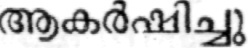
ആകര്‍ഷിച്ചു
